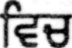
ਵਿਚ
